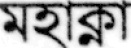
মহাক্না
